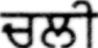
ਚਲੀ
